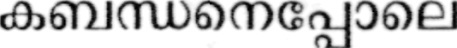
കബന്ധനെപ്പോലെ
